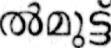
ല്‍മുട്ട്
